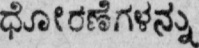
ಧೋರಣೆಗಳನ್ನು
